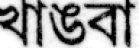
খাঙবা
